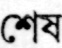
শেষ
